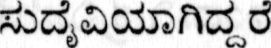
ಸುದೈವಿಯಾಗಿದ್ದರೆ
